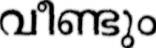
വീണ്ടും
